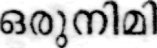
ഒരുനിമി
